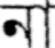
না
